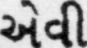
એવી
